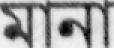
মানা
